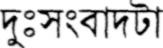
দুঃসংবাদটা
